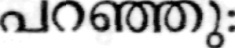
പറഞ്ഞു:
